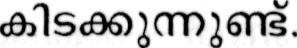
കിടക്കുന്നുണ്ട്.
